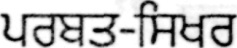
ਪਰਬਤ-ਸਿਖਰ
